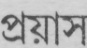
প্ৰয়াস
